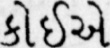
કોઈએ
